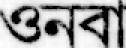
ওনবা
